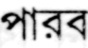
পারব
